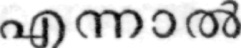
എന്നാല്‍
